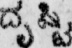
ದೃಷ್ಟಿ
